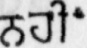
ਨਹੀਂ
